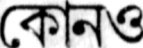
কোনও
